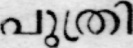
പുത്രി
